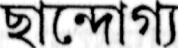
ছান্দোগ্য
